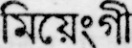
মিয়েংগী
